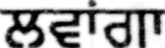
ਲਵਾਂਗਾ
